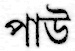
পাউ
